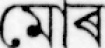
মোৰ
